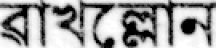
ৱাখল্লোন
